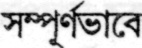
সম্পূর্ণভাবে
